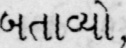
બતાવ્યો,
